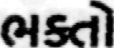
ભક્તો
